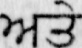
ਅਤੇ
